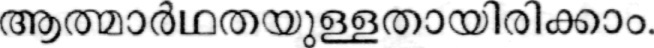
ആത്മാര്‍ഥതയുള്ളതായിരിക്കാം.
